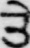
ਤੇ
